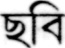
ছবি
